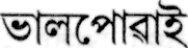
ভালপোৱাই
